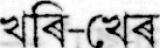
খৰি-খেৰ
